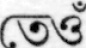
তেওঁ
